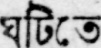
ঘটিতে
